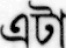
এটা
